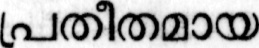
പ്രതീതമായ
